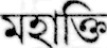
মহাক্তি
